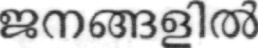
ജനങ്ങളില്‍
